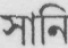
সানি
